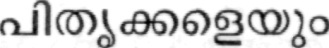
പിതൃക്കളെയും
